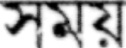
সময়
